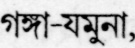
গঙ্গা-যমুনা,
